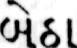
બેઠા
